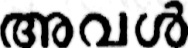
അവള്‍
